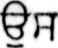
ਉਸ
